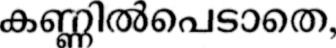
കണ്ണില്‍പെടാതെ,
